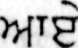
ਆਏ
